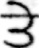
ਤੇ
